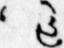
'હે
